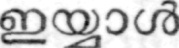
ഇയ്യാള്‍
